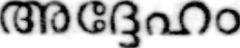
അദ്ദേഹം
